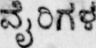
ವೈರಿಗಳ
